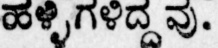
ಹಳ್ಳಿಗಳಿದ್ದವು.
